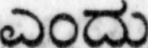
ಎಂದು
